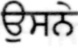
ਉਸਨੇ
